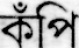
কঁপি
